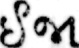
ઈજા
